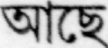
আছে
